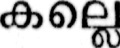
കല്ലെ
